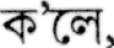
ক'লে,
